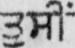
ਤੁਸੀਂ
